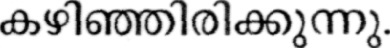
കഴിഞ്ഞിരിക്കുന്നു.
